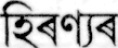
হিৰণ্যৰ
